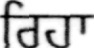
ਰਿਹਾ
